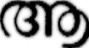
ആ
